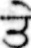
ਤੇ
